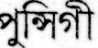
পুন্সিগী
